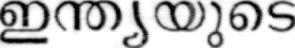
ഇന്ത്യയുടെ
